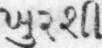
ખુરશી
